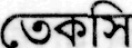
তেকসি
